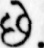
છે.
